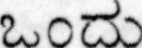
ಒಂದು
